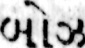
બોઝ
